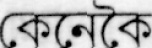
কেনেকৈ
